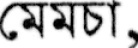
মেমচা,
